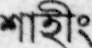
শাহীং
